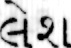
લેશ
